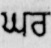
ਘਰ
